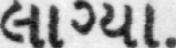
લાગ્યા.
